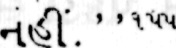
નહીં."૧૫૫
